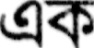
এক
